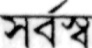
সর্বস্ব
